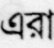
এরা
